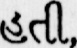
હતી,
